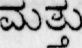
ಮತ್ತು
